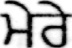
ਮੇਰੇ
